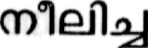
നീലിച്ച
